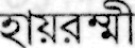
হায়রম্মী
